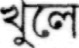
খুলে
